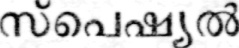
സ്പെഷ്യല്‍
